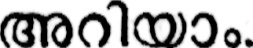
അറിയാം.
